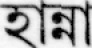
হান্না
